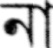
না
